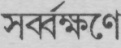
সৰ্ব্বক্ষণে
